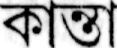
কান্তা
